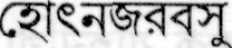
হোৎনজরবসু
